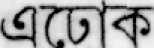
এঢোক
